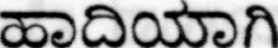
ಹಾದಿಯಾಗಿ
